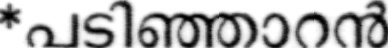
*പടിഞ്ഞാറന്‍
